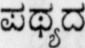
ಪಥ್ಯದ
